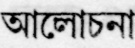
আলোচনা
